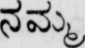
ನಮ್ಮ
